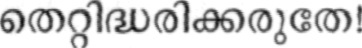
തെറ്റിദ്ധരിക്കരുതേ!
